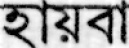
হায়বা
